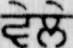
ਵੇਲੇ
